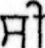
ਸੀ
